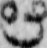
ಆ
